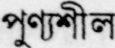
পুণ্যশীল
